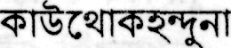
কাউথোকহন্দুনা
